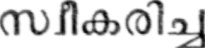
സ്വീകരിച്ച
